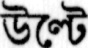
উল্টে
